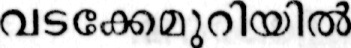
വടക്കേമുറിയില്‍
